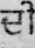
ਦੀ
